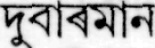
দুবাৰমান
